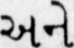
અને
